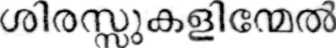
ശിരസ്സുകളിന്മേല്‍
